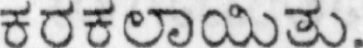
ಕರಕಲಾಯಿತು.
